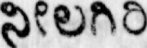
ನೀಲಗಿರಿ
